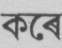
কৰে
